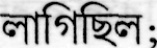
লাগিছিল;
